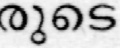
രുടെ
